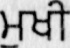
ਮੁਖੀ
